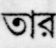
তার
